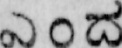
ಎಂದ
